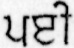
ਪਈ
